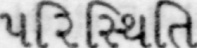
પરિસ્થિતિ
